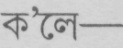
ক'লে-
